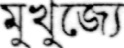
মুখুজ্যে
